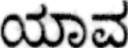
ಯಾವ
